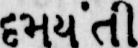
દમયંતી
